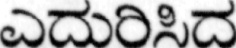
ಎದುರಿಸಿದ
